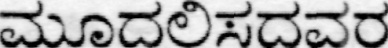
ಮೂದಲಿಸದವರ
